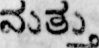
ಮತ್ತು
